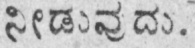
ನೀಡುವುದು.
